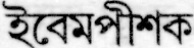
ইবেমপীশক
